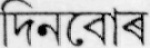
দিনবোৰ
